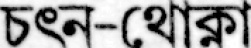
চৎন-থোক্না
